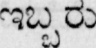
ಇಬ್ಬರು
